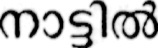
നാട്ടില്‍
